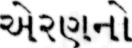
એરણનો
